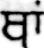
ਥਾਂ
